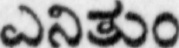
ಎನಿತುಂ
